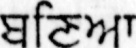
ਬਣਿਆ
